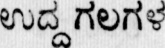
ಉದ್ದಗಲಗಳ
